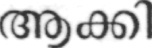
ആക്കി
